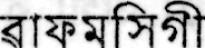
ৱাফমসিগী
